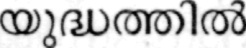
യുദ്ധത്തില്‍
